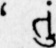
'તું
